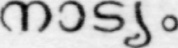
നാട്യം
